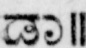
ಡಾ||
